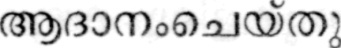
ആദാനംചെയ്തു
